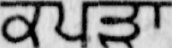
ਕਪੜਾ
